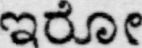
ಇರೋ
